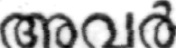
അവര്‍
